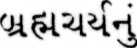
બ્રહ્મચર્યનું
